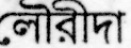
লৌরীদা
